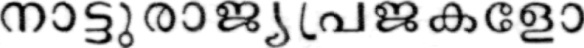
നാട്ടുരാജ്യപ്രജകളോ
